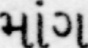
માંગ
